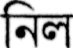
নিল
